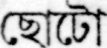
ছোটো
